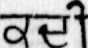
ਕਦੀ
